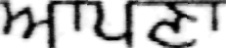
ਆਪਣਾ
